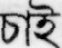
চাই
